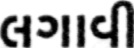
લગાવી
